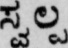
ಸ್ವಲ್ಪ
